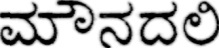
ಮೌನದಲಿ
